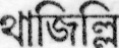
থাজিল্লি
